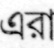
এরা
